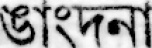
ঙাংদনা
